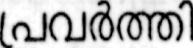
പ്രവര്‍ത്തി
